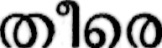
തീരെ
